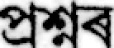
প্রশ্নৰ
